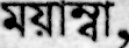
ময়াম্বা,
